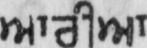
ਆਰੀਆ
